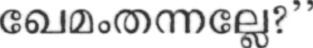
ഖേമംതന്നല്ലേ?"
